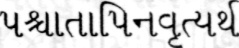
પશ્વાતાપિનવૃત્યર્થ
